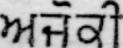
ਅਜੋਕੀ
